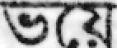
ভয়ে
